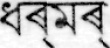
ধৰ‌্মৰ্
